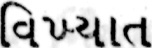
વિખ્યાત
